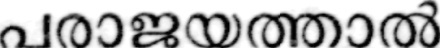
പരാജയത്താല്‍
